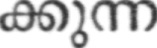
ക്കുന്ന
